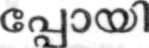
പ്പോയി
